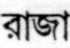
রাজা
